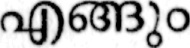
എങ്ങും
